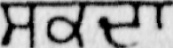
ਸਕਦਾ
